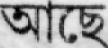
আছে
